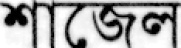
শাজেল
